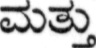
ಮತ್ತು
